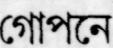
গোপনে
